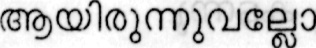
ആയിരുന്നുവല്ലോ
